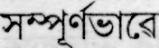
সম্পূর্ণভাৱে
